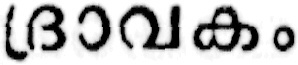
ദ്രാവകം
